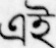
এই
